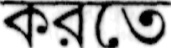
করতে
